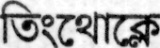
তিংথোক্লে
